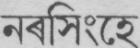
নৰসিংহে
